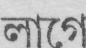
লাগে
